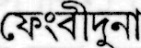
ফেংবীদুনা
